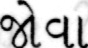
જોવા
